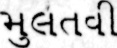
મુલતવી
